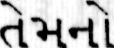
તેમનો
